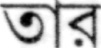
তার
